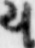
ય
